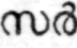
സര്‍
